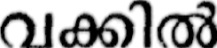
വക്കില്‍
